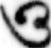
ও
